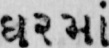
ઘરમાં
